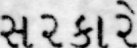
સરકારે
